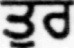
ਤੁਰ
